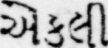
એકલી
